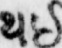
થઈ
